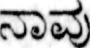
ನಾವು
